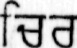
ਚਿਰ
